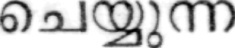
ചെയ്യുന്ന
